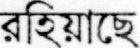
রহিয়াছে
